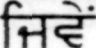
ਜਿਵੇਂ
